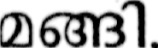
മങ്ങി.
